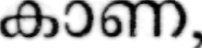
കാണ,
